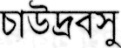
চাউদ্রবসু
